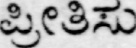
ಪ್ರೀತಿಸು
